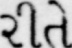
રીતે
